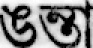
ঙন্তা
